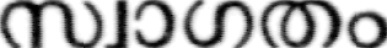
സ്വാഗതം
